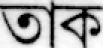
তাক
